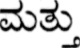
ಮತ್ತು
